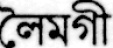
লৈমগী
